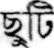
ছুটি
